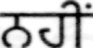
ਨਹੀਂ
